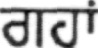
ਗਹਾਂ
